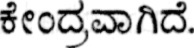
ಕೇಂದ್ರವಾಗಿದೆ.
